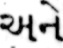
અને
